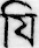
যি
